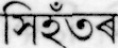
সিহঁতৰ
